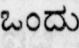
ಒಂದು
